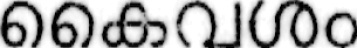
കൈവശം
